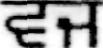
ਵਜ
